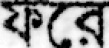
ফরে
